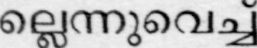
ല്ലെന്നുവെച്ച്
